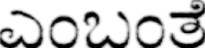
ಎಂಬಂತೆ
